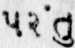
પરંતુ
